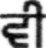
ਵੀ
